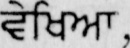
ਵੇਖਿਆ,
